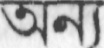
অন্য
